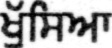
ਖੁੱਸਿਆ
